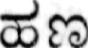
ಹಣ
